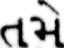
તમે
